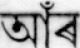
আঁৰ
